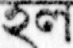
হল
